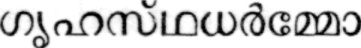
ഗൃഹസ്ഥധര്‍മ്മോ
